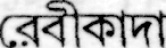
রেবীকাদা
